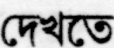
দেখতে
